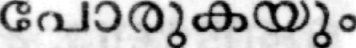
പോരുകയും
